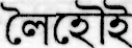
লৈহৌই
